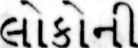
લોકોની
